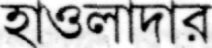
হাওলাদার
